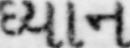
ઘ્યાન
